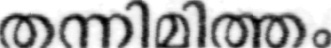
തന്നിമിത്തം
